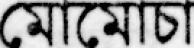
মোমোচা
